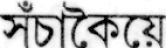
সঁচাকৈয়ে
